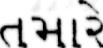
તમારે
